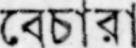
বেচারা
